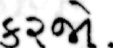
કરજો.
